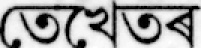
তেখেতৰ
